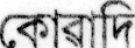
কোৱাদি
